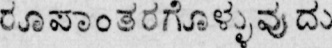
ರೂಪಾಂತರಗೊಳ್ಳುವುದು
